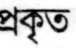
প্রকৃত
